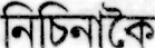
নিচিনাকৈ
